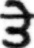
ਤੇ
